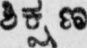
ಶಿಕ್ಷಣ
